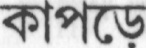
কাপড়ে
